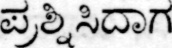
ಪ್ರಶ್ನಿಸಿದಾಗ
